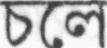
চলে
